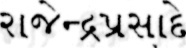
રાજેન્દ્રપ્રસાદે
